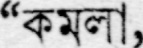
‘‘কমলা,
